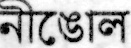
নীঙোল
